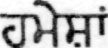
ਹਮੇਸ਼ਾਂ
